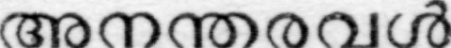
അനന്തരവള്‍
